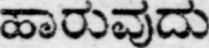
ಹಾರುವುದು
